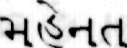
મહેનત
